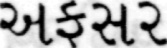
અફસર
